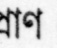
প্রাণ
